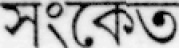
সংকেত
